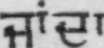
ਜਾਂਦਾ
